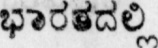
ಭಾರತದಲ್ಲಿ
